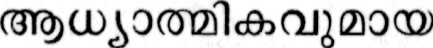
ആധ്യാത്മികവുമായ
